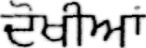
ਦੋਖੀਆਂ
